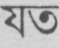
যত
